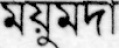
ময়ুমদা
